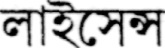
লাইসেন্স
